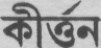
কীৰ্ত্তন
